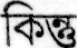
কিন্তু
